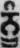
ਨੂੰ
